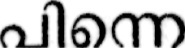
പിന്നെ
